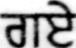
ਗਏ
